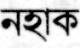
নহাক
